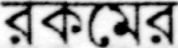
রকমের
